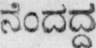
ನೆಂದದ್ದ
